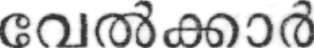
വേല്‍ക്കാര്‍
